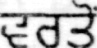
ਵਰਤੋਂ
